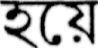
হয়ে
